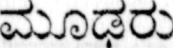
ಮೂಢರು
